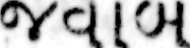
જવાબ
